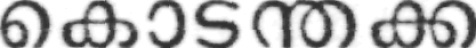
കൊടന്തക്ക
